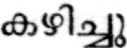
കഴിച്ചു
